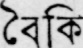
বৈকি
